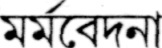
মর্মবেদনা
